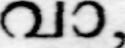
വാ,
